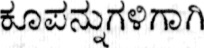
ಕೂಪನ್ನುಗಳಿಗಾಗಿ
